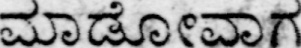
ಮಾಡೋವಾಗ
